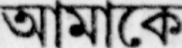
আমাকে
